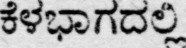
ಕೆಳಭಾಗದಲ್ಲಿ
